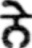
ਨੇ
